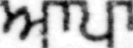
ਆਪਾ
